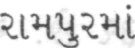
રામપુરમાં
